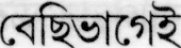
বেছিভাগেই
